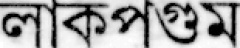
লাকপগুম
